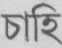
চাহি
